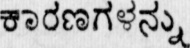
ಕಾರಣಗಳನ್ನು
